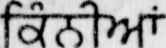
ਕਿੰਨੀਆਂ
